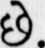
છે.
